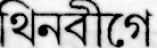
থিনবীগে
